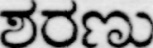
ಶರಣು
